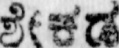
ಶೇಕಡ
